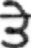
ਤੇ
